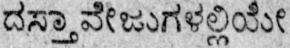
ದಸ್ತಾವೇಜುಗಳಲ್ಲಿಯೇ
